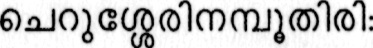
ചെറുശ്ശേരിനമ്പൂതിരി:
